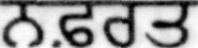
ਨਫ਼ਰਤ
